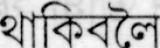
থাকিবলৈ
